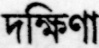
দক্ষিণা
